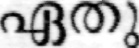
ഏതു
